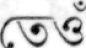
তেওঁ
